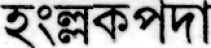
হংল্লকপদা
